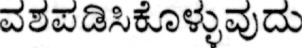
ವಶಪಡಿಸಿಕೊಳ್ಳುವುದು
